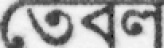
তেবল
